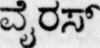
ವೈರಸ್
